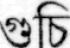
গুচি
